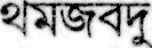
থমজবদু
